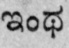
ಇಂಥ
